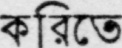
করিতে
